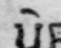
ਪੇਸ਼
